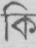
কি
